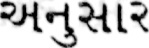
અનુસાર
